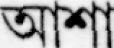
আশা
